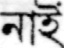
নাই
